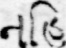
નહિં
